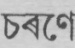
চৰণে
